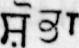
ਸ਼ੋਭਾ
